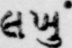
લખું
